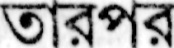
তারপর
